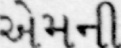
એમની
